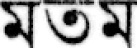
মতম
